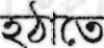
হঠাতে
